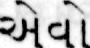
એવો
